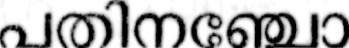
പതിനഞ്ചോ
